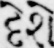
દેશે
